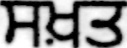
ਸਖ਼ਤ
